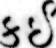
કઇ
